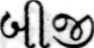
બીજી
